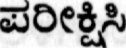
ಪರೀಕ್ಷಿಸಿ
